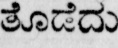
ತೊಡೆದು
